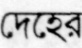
দেহের
